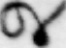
જ
